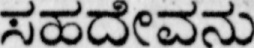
ಸಹದೇವನು
